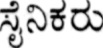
ಸೈನಿಕರು
